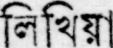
লিখিয়া
